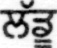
ਲੱਡੂ
